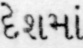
દેશમાં
